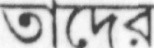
তাদের
